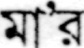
মা’র
